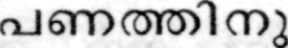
പണത്തിനു
